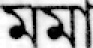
মমা
